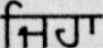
ਜਿਹਾ
